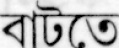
বাটতে
